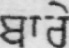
ਬਾਰੇ
